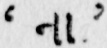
'ના.'
